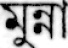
মুন্না
